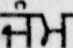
ਜੰਮ
